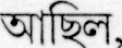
আছিল,
